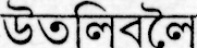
উতলিবলৈ
